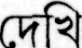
দেখি
